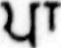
ਪਾ
